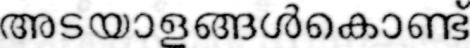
അടയാളങ്ങള്‍കൊണ്ട്
